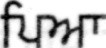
ਪਿਆ
